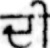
ਦੀ
